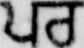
ਪਰ
